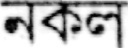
নকল
